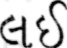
લઈ
